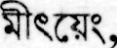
মীৎয়েং,
